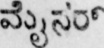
ಮೈನರ್
